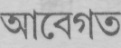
আবেগত
